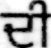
ਦੀ
